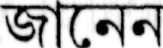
জানেন
